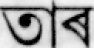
তাৰ
